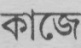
কাজে
